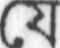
যে
